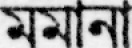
মমানা
